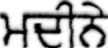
ਮਦੀਨੇ
